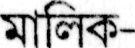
মালিক-
